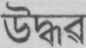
উদ্ধৱ
